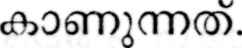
കാണുന്നത്.
